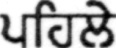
ਪਹਿਲੇ
